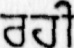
ਰਹੀ
